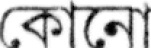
কোনো
